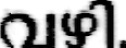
വഴി.
